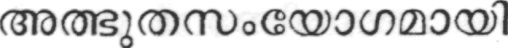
അത്ഭുതസംയോഗമായി
